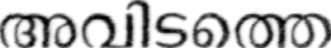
അവിടത്തെ
